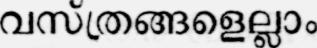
വസ്ത്രങ്ങളെല്ലാം
